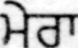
ਮੇਰਾ
